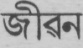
জীৱন
